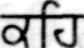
ਕਹਿ
